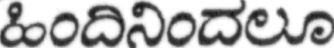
ಹಿಂದಿನಿಂದಲೂ
